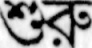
শুরু
